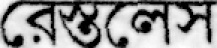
রেস্তলেস
